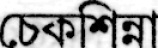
চেকশিন্না
